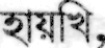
হায়খি,
